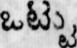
ಒಟ್ಟು
